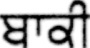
ਬਾਕੀ
